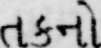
તકનો
